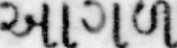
આગળ
